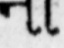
ના
